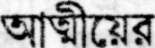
আত্মীয়ের
